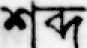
শব্দ
